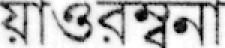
য়াওরম্বনা
